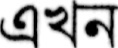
এখন
